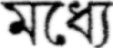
মধ্যে
